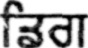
ਡਿਗ
